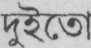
দুইতো
